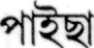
পাইছা
